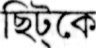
ছিট্‌কে
